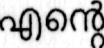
എന്റെ
